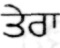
ਤੇਰਾ
